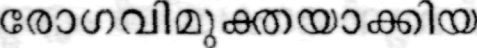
രോഗവിമുക്തയാക്കിയ
